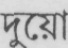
দুয়ো
